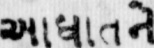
આધાતને
